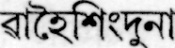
ৱাহৈশিংদুনা
